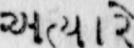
અત્યારે
